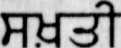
ਸਖ਼ਤੀ
